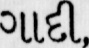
ગાદી,
